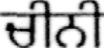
ਚੀਨੀ
